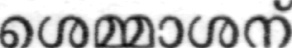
ശെമ്മാശന്
